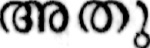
അതു
